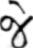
જે
